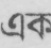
এক
